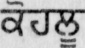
ਕੋਹਲੂ
